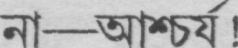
না-আশ্চর্য!
